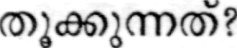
തൂക്കുന്നത്?
